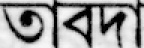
তাবদা
